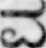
ವ
